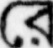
রে
